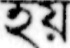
হয়
